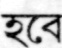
হবে
